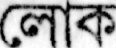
লোক
